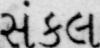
સંકલ
